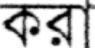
করা
